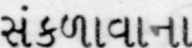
સંકળાવાના
